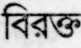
বিরক্ত
